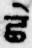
ਛੇ
